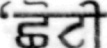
'ਛੋਟੀ
